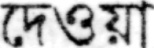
দেওয়া
